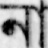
না
